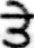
ਤੇ
